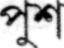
পুশ
